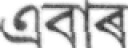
এবাৰ
